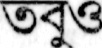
তবুও
